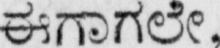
ಈಗಾಗಲೇ,
